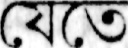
যেতে
